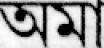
অমা
